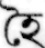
হৈ
